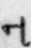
ન
